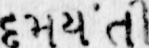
દમયંતી
